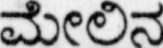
ಮೇಲಿನ
